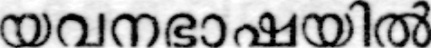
യവനഭാഷയില്‍
